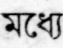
মধ্যে
